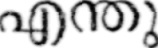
എന്തു
